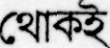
থোকই
